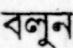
বলুন
